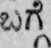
ಬಗ್ಗೆ
